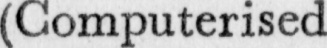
(Computerized
